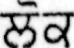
ਲੋਕ
